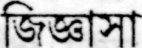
জিজ্ঞাসা
